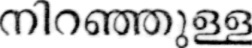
നിറഞ്ഞുള്ള
